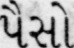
પૈસો
